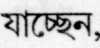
যাচ্ছেন,
